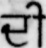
ਦੀ
